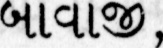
બાવાજી,
